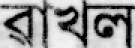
ৱাখল
